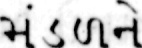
મંડળને
